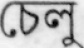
চেলু
